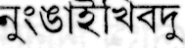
নুংঙাইখিবদু
